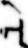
ને
